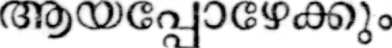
ആയപ്പോഴേക്കും
